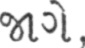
જાગે,
